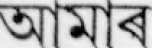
আমাৰ
